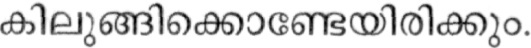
കിലുങ്ങിക്കൊണ്ടേയിരിക്കും.
